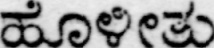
ಹೊಳೀತು
